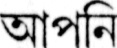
আপনি
